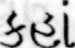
કહાં
